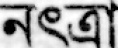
নৎত্রা
